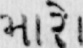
મારો
